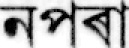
নপৰা
